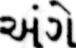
અંગે
